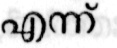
എന്ന്
